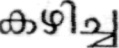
കഴിച്ച
